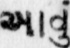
આવું
